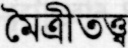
মৈত্রীতত্ত্ব
